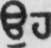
ਉਹ
